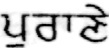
ਪੁਰਾਣੇ
